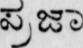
ಪ್ರಜಾ
